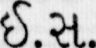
ઈ.સ.
